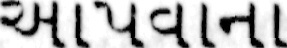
આપવાના
